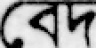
বেদ
